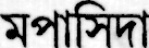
মপাসিদা
